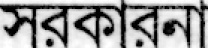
সরকারনা
